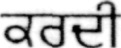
ਕਰਦੀ
